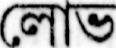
লোভ
